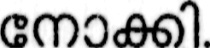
നോക്കി.
